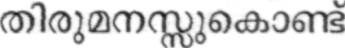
തിരുമനസ്സുകൊണ്ട്
